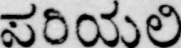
ಪರಿಯಲಿ
